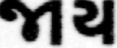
જાય
